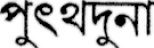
পুৎথদুনা
